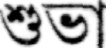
শুভা
